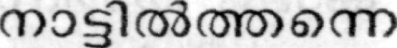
നാട്ടില്‍ത്തന്നെ
